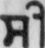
ਸੀ
